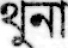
থুনা
